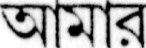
আমার
